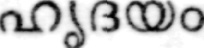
ഹൃദയം
